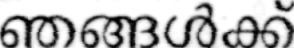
ഞങ്ങള്‍ക്ക്
